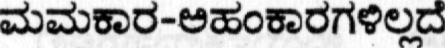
ಮಮಕಾರ-ಅಹಂಕಾರಗಳಿಲ್ಲದೆ
